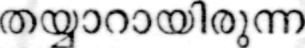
തയ്യാറായിരുന്ന
